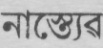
নাস্ত্যেৱ
